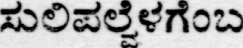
ಸುಲಿಪಲ್ವೆಳಗೆಂಬ
